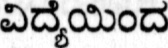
ವಿದ್ಯೆಯಿಂದ
